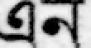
এন
